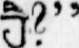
ਹੈ?''
